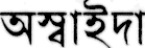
অস্বাইদা
